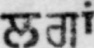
ਲਗਾਂ
